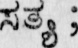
ಸತ್ಯ;
